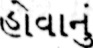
હોવાનું
